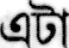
এটা
